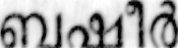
ബഷീര്‍
